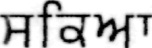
ਸਕਿਆ
